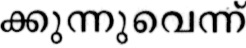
ക്കുന്നുവെന്ന്
